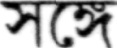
সঙ্গে
